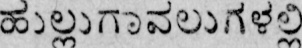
ಹುಲ್ಲುಗಾವಲುಗಳಲ್ಲಿ
